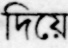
দিয়ে
